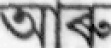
আৰু
